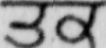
ਤਕ
